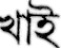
খাই
